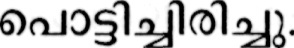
പൊട്ടിച്ചിരിച്ചു.
